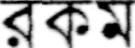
রকম
